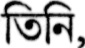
তিনি,
